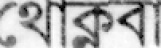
থোক্নবা
